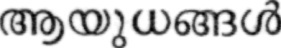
ആയുധങ്ങള്‍
